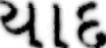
યાદ
